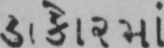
ડાકોરમાં
